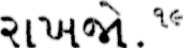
રાખજો.૧૯
